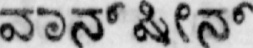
ವಾನ್‌ಷೀನ್
